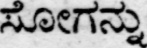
ಸೋಗನ್ನು
